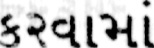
કરવામાં
